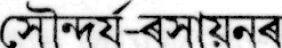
সৌন্দর্য-ৰসায়নৰ
